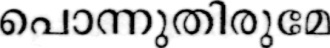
പൊന്നുതിരുമേ
